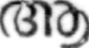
ആ
